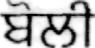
ਬੋਲੀ
